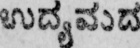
ಉದ್ಯಮದ
